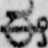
ಈ
